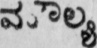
ಮೌಲ್ಯ
